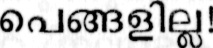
പെങ്ങളില്ല!
